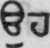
ਉਹ
